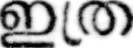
ഇത്ര
